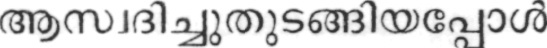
ആസ്വദിച്ചുതുടങ്ങിയപ്പോള്‍
